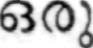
ഒരു
